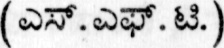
(ಎಸ್.ಎಫ್.ಟಿ)
